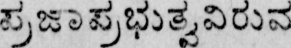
ಪ್ರಜಾಪ್ರಭುತ್ವವಿರುವ
